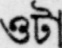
ওটা
